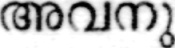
അവനു
